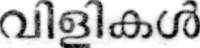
വിളികള്‍
